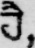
ਹੈ,
